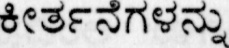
ಕೀರ್ತನೆಗಳನ್ನು
